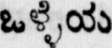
ಒಳ್ಳೆಯ
